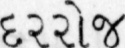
દરરોજ
